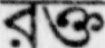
রক্ত
